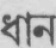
ধান
